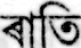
ৰাতি
